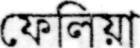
ফেলিয়া
